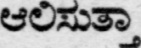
ಆಲಿಸುತ್ತಾ
